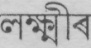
লক্ষ্মীৰ
